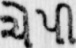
ચેપી
